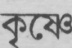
কৃষ্ণে
